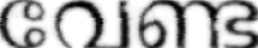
വേണ്ട
